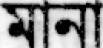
মানা
